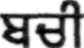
ਬਚੀ
